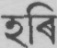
হৰি
